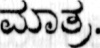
ಮಾತ್ರ.
